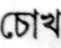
চোখ
